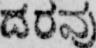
ದರವು
